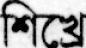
শিখ্রে
